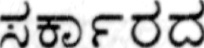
ಸರ್ಕಾರದ
